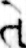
તે
